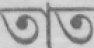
তাত
